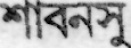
শাবনসু
